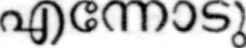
എന്നോടു
